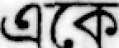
একে
